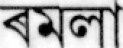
ৰমলা
